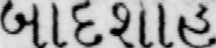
બાદશાહ
